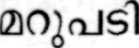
മറുപടി
